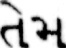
તેમ
